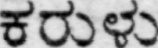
ಕರುಳು
